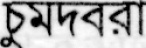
চুমদবরা
